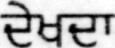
ਦੇਖਦਾ
